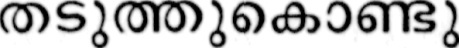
തടുത്തുകൊണ്ടു
